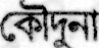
কৌদুনা
